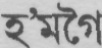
হ'মগৈ
